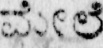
ಮೇಲೆ
